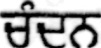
ਚੰਦਨ
